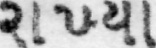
રાખ્યા
